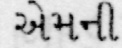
એમની
